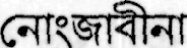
নোংজাবীনা
